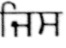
ਜਿਸ
